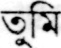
তুমি
